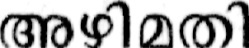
അഴിമതി
